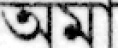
অমা
